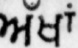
ਅੱਖਾਂ
